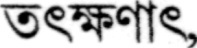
তৎক্ষণাৎ,
